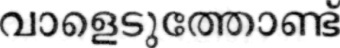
വാളെടുത്തോണ്ട്
